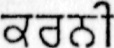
ਕਰਨੀ
